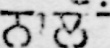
ਨਾਲੋਂ
